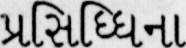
પ્રસિધ્ધિના
